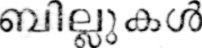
ബില്ലുകള്‍
